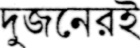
দুজনেরই
